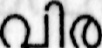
വിര
